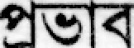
প্রভাব
